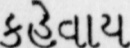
કહેવાય
